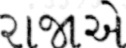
રાજાએ
